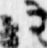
કરે
